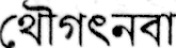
থৌগৎনবা
